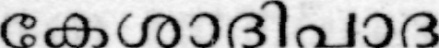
കേശാദിപാദ
